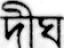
দীঘ
